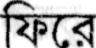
ফিরে
